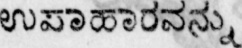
ಉಪಾಹಾರವನ್ನು
